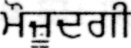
ਮੌਜ਼ੂਦਗੀ
